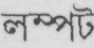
লম্পট
